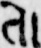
તો
